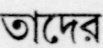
তাদের
